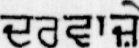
ਦਰਵਾਜ਼ੇ
